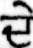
ਦੇ
